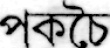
পকচৈ
